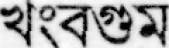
খংবগুম
